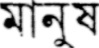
মানুষ
